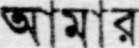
আমার
